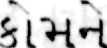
કોમને
